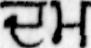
ਦਮ
